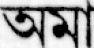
অমা
